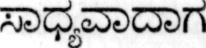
ಸಾಧ್ಯವಾದಾಗ
